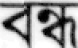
বন্ধ
